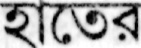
হাতের
